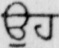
ਉਹ
